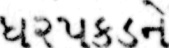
ધરપકડને
